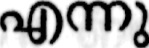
എന്നു
